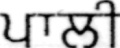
ਪਾਲੀ
